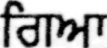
ਗਿਆ
